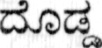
ದೊಡ್ಡ
